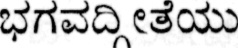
ಭಗವದ್ಗೀತೆಯು
